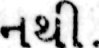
નથી.
